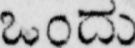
ಒಂದು
